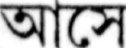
আসে
